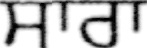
ਸਾਰਾ
